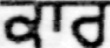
ਕਾਰ
